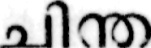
ചിന്ത
